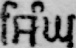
ਸਿੰਘ
